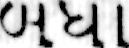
બધા
